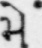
મેં
